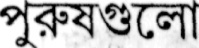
পুরুষগুলো
